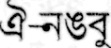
ঐ-নঙবু
